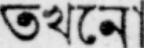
তখনো
